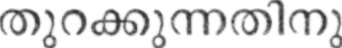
തുറക്കുന്നതിനു
